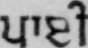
ਪਾਈ
